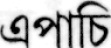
এপাচি
